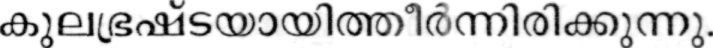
കുലഭ്രഷ്ടയായിത്തീര്‍ന്നിരിക്കുന്നു.
